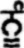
ਨੂੰ
